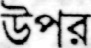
উপর
